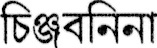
চিঞ্জবনিনা
